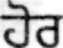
ਹੋਰ
